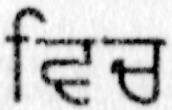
ਵਿਚ
